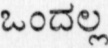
ಒಂದಲ್ಲ
